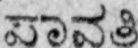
ಪಾವತಿ
